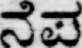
ನೆಪ
